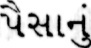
પૈસાનું
